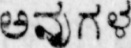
ಅವುಗಳ
